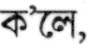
ক'লে,
